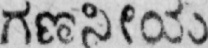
ಗಣನೀಯ
